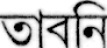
তাবনি
